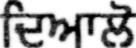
ਦਿਆਲੋ
